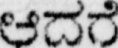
ಆದರೆ
